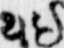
થઈ
